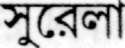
সুরেলা
